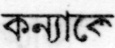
কন্যাকে
